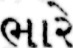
ભારે
